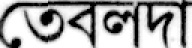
তেবলদা
